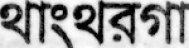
থাংথরগা
